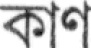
কাণ
